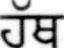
ਹੱਥ
